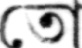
তো
